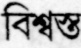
বিশ্বস্ত
